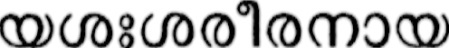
യശംഃശരീരനായ
